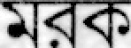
মরক
